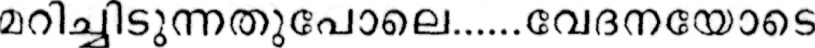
മറിച്ചിടുന്നതുപോലെ......വേദനയോടെ
